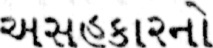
અસહકારનો
